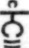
ਨੂੰ
